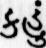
કહું
